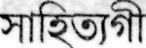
সাহিত্যগী
